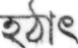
হঠাৎ
